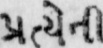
પ્રત્યેની
